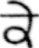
ਕੇ
